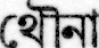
থৌনা
